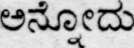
ಅನ್ನೋದು
